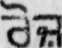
ਰੋਜ਼
